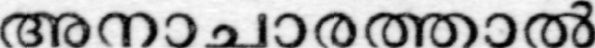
അനാചാരത്താല്‍
